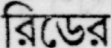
রিডের
